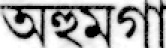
অহুমগা
